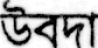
উবদা
